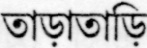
তাড়াতাড়ি
